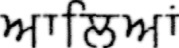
ਆਲਿਆਂ
